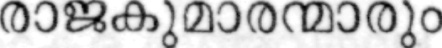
രാജകുമാരന്മാരും
